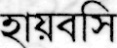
হায়বসি
